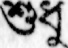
শুধু
